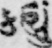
કહ્યું
